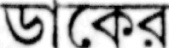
ডাকের
